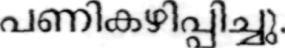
പണികഴിപ്പിച്ചു.
